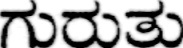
ಗುರುತು
